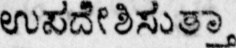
ಉಪದೇಶಿಸುತ್ತಾ
